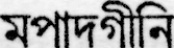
মপাদগীনি
